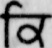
ਕਿ
